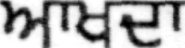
ਆਖਦਾ
